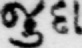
જુદા
